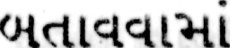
બતાવવામાં
